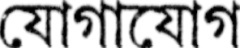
যোগাযোগ
